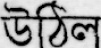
উঠিল
